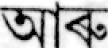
আৰু
